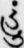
હું
